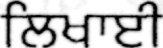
ਲਿਖਾਈ
